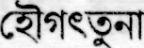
হৌগৎতুনা
